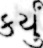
કર્યું
